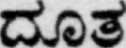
ದೂತ
